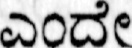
ಎಂದೇ
